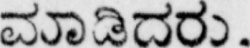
ಮಾಡಿದರು.
